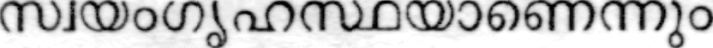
സ്വയംഗൃഹസ്ഥയാണെന്നും
